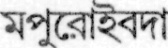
মপুরোইবদা
